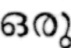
ഒരു
